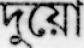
দুয়ো
